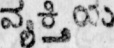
ವ್ಯಕ್ತಿಯ
